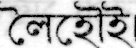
লৈহৌই।
